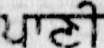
ਪਾਣੀ
